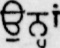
ਉਨ੍ਹਾਂ
